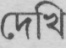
দেখি
